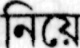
নিয়ে
